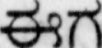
ಈಗ
